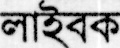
লাইবক
